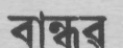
বান্ধৱ
